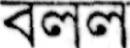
বলল
